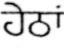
ਹੇਠਾਂ
